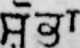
ਸ਼ੋਭਾ
